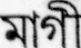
মাগী
